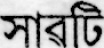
সাৱটি
